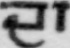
ਦਾ
